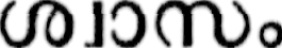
ശ്വാസം
